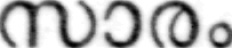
സാരം
